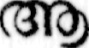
ആ
